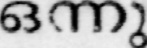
ഒന്നു
